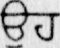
ਉਹ
